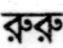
রুরু
